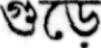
গুড়ে
